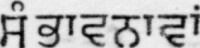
ਸੰਭਾਵਨਾਵਾਂ
